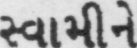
સ્વામીને
